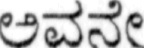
ಅವನೇ
